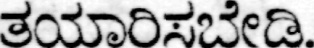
ತಯಾರಿಸಬೇಡಿ.
